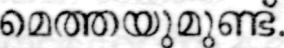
മെത്തയുമുണ്ട്.
